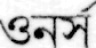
ওনর্স
